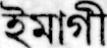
ইমাগী
